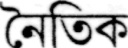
নৈতিক
